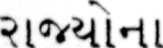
રાજ્યોના
